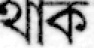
থাক
